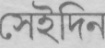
সেইদিন
